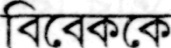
বিবেককে
